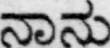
ನಾನು
